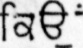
ਕਿਉਂ
